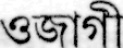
ওজাগী
